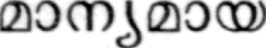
മാന്യമായ
